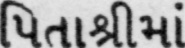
પિતાશ્રીમાં
